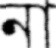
না
